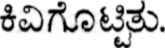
ಕಿವಿಗೊಟ್ಟಿತು.
